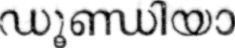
ഡൂണ്ഡിയാ
